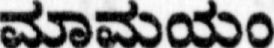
ಮಾಮಯಂ
